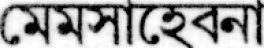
মেমসাহেবনা
